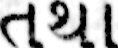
તથા
